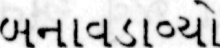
બનાવડાવ્યો
